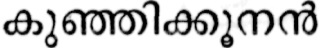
കുഞ്ഞിക്കൂനന്‍
